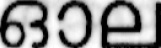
ഓല
